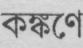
কঙ্কণে
